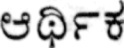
ಆರ್ಥಿಕ
